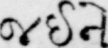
જઈને
